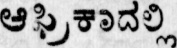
ಆಫ್ರಿಕಾದಲ್ಲಿ
